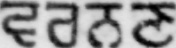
ਵਰਨਣ
